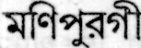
মণিপুরগী
